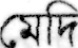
মেদি
